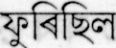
ফুৰিছিল
